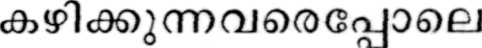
കഴിക്കുന്നവരെപ്പോലെ
